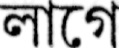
লাগে
